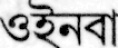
ওইনবা
